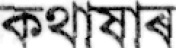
কথাষাৰ
